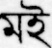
মই
